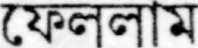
ফেললাম
